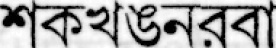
শকখঙনরবা
